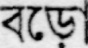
বড়ো
